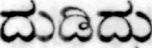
ದುಡಿದು
